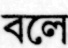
বলে
